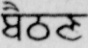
ਬੈਠਣ
